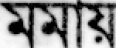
মমায়
